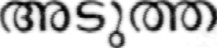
അടുത്ത
